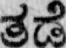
ತಡೆ
